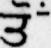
ਤੋਂ
